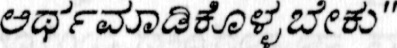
ಅರ್ಥಮಾಡಿಕೊಳ್ಳಬೇಕು”
